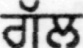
ਗੱਲ
